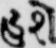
હશે
